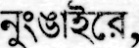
নুংঙাইরে,
